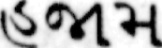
હજામ
